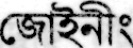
জোইনীং
